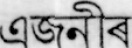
এজনীৰ
